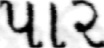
પાર
